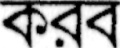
করব
